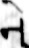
ને
